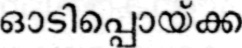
ഓടിപ്പൊയ്ക്ക
